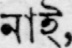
নাই,
